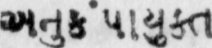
અનુકંપાયુક્ત
